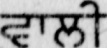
ਵਾਲੀ
